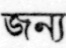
জন্য
